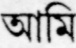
আমি
